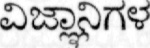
ವಿಜ್ಞಾನಿಗಳ
